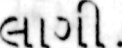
લાગી.
